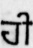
ਹੀ
